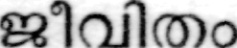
ജീവിതം
